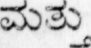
ಮತ್ತು
